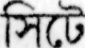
সিটে
